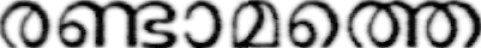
രണ്ടാമത്തെ
